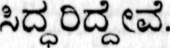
ಸಿದ್ಧರಿದ್ದೇವೆ.
